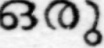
ഒരു
